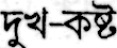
দুখ-কষ্ট
